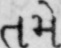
તમે
